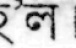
হ'ল
